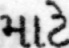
માટે
